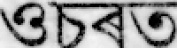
ওচৰত
